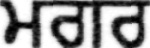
ਮਗਰ
